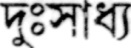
দুঃসাধ্য
